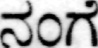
ನಂಗೆ
